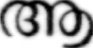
ആ
